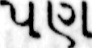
પણ
